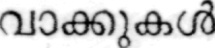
വാക്കുകള്‍
